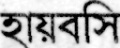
হায়বসি
